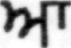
ਆ
